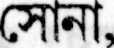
সোনা,
